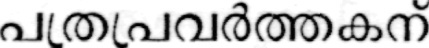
പത്രപ്രവര്‍ത്തകന്
